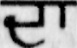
ਦਾ
